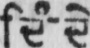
ਦਿੰਦੇ
